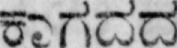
ಕಾಗದದ
